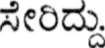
ಸೇರಿದ್ದು.
